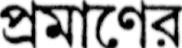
প্রমাণের
